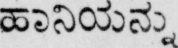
ಹಾನಿಯನ್ನು
